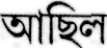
আছিল
